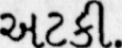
અટકી.
